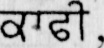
ਕਾਫੀ,
